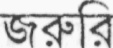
জরুরি
